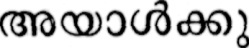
അയാള്‍ക്കു
